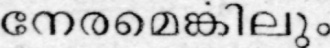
നേരമെങ്കിലും
